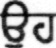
ਉਹ
